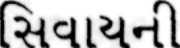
સિવાયની
